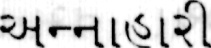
અન્નાહારી
